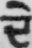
ਦੇ
